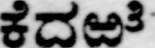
ಕೆದಱೆ
